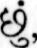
છું,
